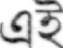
এই
